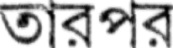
তারপর
